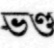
ভণ্ড
